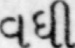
વધી
